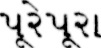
પૂરેપૂરા
